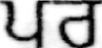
ਪਰ
